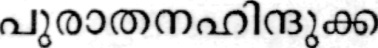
പുരാതനഹിന്ദുക്ക
